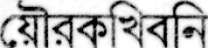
য়ৌরকখিবনি
